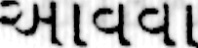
આવવા
